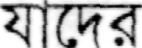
যাদের
